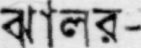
ঝালর-
